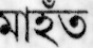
মাহঁত
